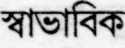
স্বাভাবিক
